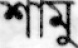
শামু
